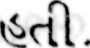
હતી.
